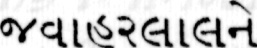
જવાહરલાલને
